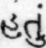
હતું
